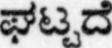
ಘಟ್ಟದೆ
